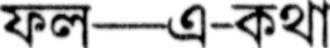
ফল-এ-কথা
